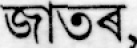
জাতৰ,
